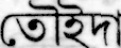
তৌইদা
